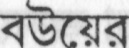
বউয়ের
